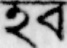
হব
